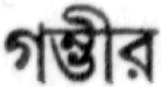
গম্ভীর
